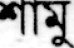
শামু
